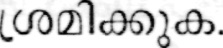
ശ്രമിക്കുക.
